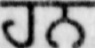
ਹਨ
